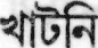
খাটনি
